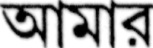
আমার
